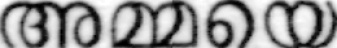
അമ്മയെ
